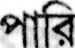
পারি
